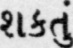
શકતું
